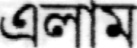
এলাম
